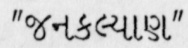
"જનકલ્યાણ"
